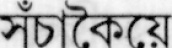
সঁচাকৈয়ে
